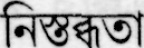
নিস্তব্ধতা
